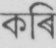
কৰি
